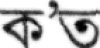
ক'ত
